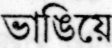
ভাঙিয়ে
